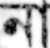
না
